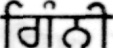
ਗਿੰਨੀ
